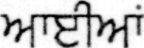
ਆਈਆਂ
